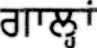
ਗਾਲ੍ਹਾਂ
